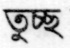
তুচ্ছ
